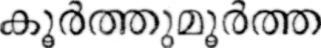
കൂര്‍ത്തുമൂര്‍ത്ത
